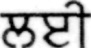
ਲਈ
